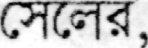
সেলের,
